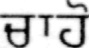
ਚਾਹੋ
